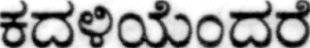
ಕದಳಿಯೆಂದರೆ
